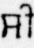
ਸੀ
